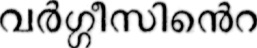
വര്‍ഗ്ഗീസിന്റെ
